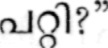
പറ്റി?"
